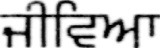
ਜੀਵਿਆ
